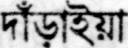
দাঁড়াইয়া
